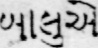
બાલુએ
